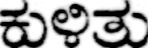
ಕುಳಿತು
